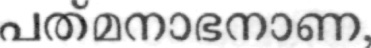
പത്മനാഭനാണ,
